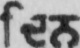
ਦਿਨ
